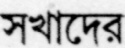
সখাদের
